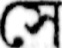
সে
